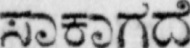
ಸಾಕಾಗದೆ
